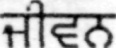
ਜੀਵਨ
